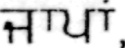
ਜਾਪਾਂ,
